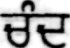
ਚੰਦ
